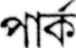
পার্ক
